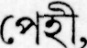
পেহী,
